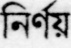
নির্ণয়
